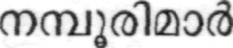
നമ്പൂരിമാര്‍
